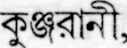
কুঞ্জরানী,
